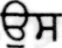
ਉਸ
